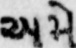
અમે
